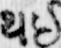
થઈ
